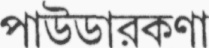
পাউডারকণা
